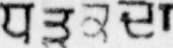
ਧੜਕਦਾ
